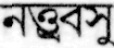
নত্ত্রবসু
